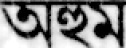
অহুম
